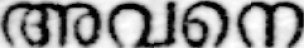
അവനെ
